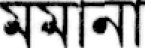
মমানা
